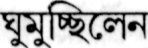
ঘুমুচ্ছিলেন
